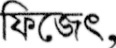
ফিজেৎ,
